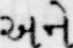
અને
